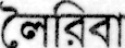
লৈরিবা
